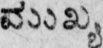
ಮುಖ್ಯ
